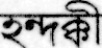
হন্দক্কী
